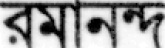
রমানন্দ
